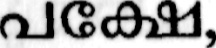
പക്ഷേ,
